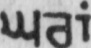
ਘਰਾਂ
